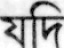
যদি
